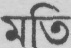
মতি
